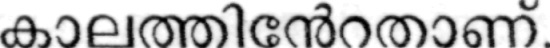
കാലത്തിന്റേതാണ്.
